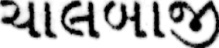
ચાલબાજી
